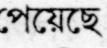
পেয়েছে
